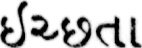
ઇચ્છતા
